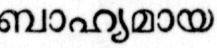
ബാഹ്യമായ
